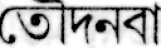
তৌদনবা
